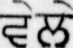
ਵੇਲੇ
